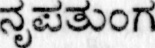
ನೃಪತುಂಗ
